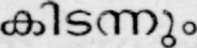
കിടന്നും
